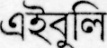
এইবুলি
